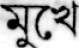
মুখে
